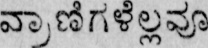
ವ್ರಾಣಿಗಳೆಲ್ಲವೂ
